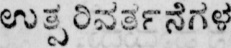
ಉತ್ಪರಿವರ್ತನೆಗಳ
